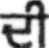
ਦੀ
